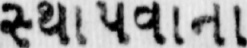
સ્થાપવાના
